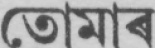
তোমাৰ
